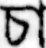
চা
